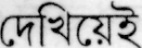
দেখিয়েই
